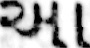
આ
